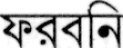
ফরবনি
